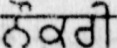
ਨੌਕਰੀ
